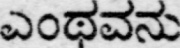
ಎಂಥವನು
